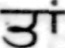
ਤਾਂ
